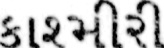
કાશ્મીરી
